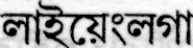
লাইয়েংলগা
